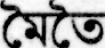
মৈতৈ
